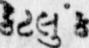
કેટલુંક
